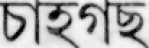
চাহগছ
